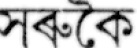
সৰুকৈ
